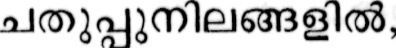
ചതുപ്പുനിലങ്ങളില്‍,
